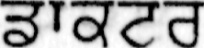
ਡਾਕਟਰ
